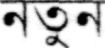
নতুন
